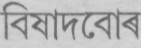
বিষাদবোৰ
